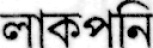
লাকপনি
